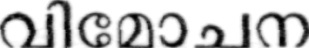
വിമോചന
